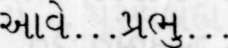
આવે...પ્રભુ....
